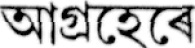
আগ্রহেৰে
